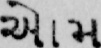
ઓમ
